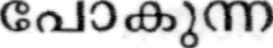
പോകുന്ന
